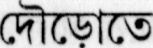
দৌড়োতে
